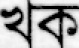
খক
